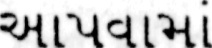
આપવામાં
